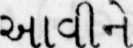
આવીને
